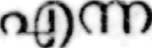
എന്ന
